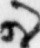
જે
